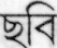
ছবি
